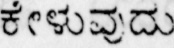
ಕೇಳುವುದು
